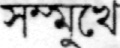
সম্মুখে
